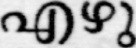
എഴു
